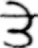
ਤੇ
